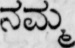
ನಮ್ಮ
